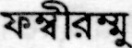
ফম্বীরম্মু
